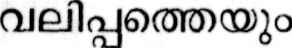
വലിപ്പത്തെയും
